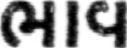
ભાવ
